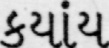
ક્યાંય
